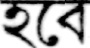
হবে
